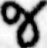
જ
